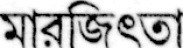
মারজিৎতা
